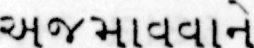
અજમાવવાને
